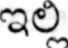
ಇಲ್ಲಿ
